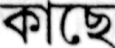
কাছে
